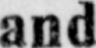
and
